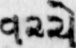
વચ્ચે
